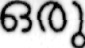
ഒരു
